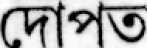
দোপত
